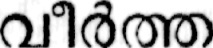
വീര്‍ത്ത
